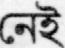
নেই
